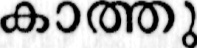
കാത്തു
